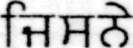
ਜਿਸਨੇ
